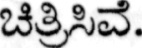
ಚಿತ್ರಿಸಿವೆ.
